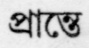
প্রান্তে
